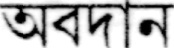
অবদান
